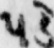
પડે
